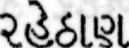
રહેઠાણ
